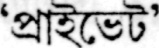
‘প্রাইভেট’
